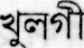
খুলগী
